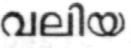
വലിയ
